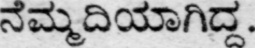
ನೆಮ್ಮದಿಯಾಗಿದ್ದ.
